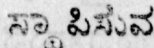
ಸ್ಥಾಪಿಸುವ
